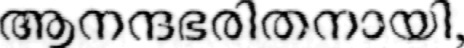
ആനന്ദഭരിതനായി,
